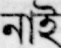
নাই
